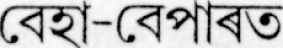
বেহা-বেপাৰত
